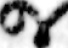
જ
